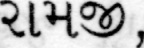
રામજી,
